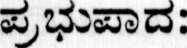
ಪ್ರಭುಪಾದ:
